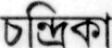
চন্দ্রিকা
